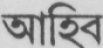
আহিব
